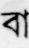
বা
